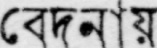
বেদনায়
